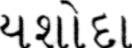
યશોદા
